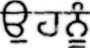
ਉਹਨੂੰ
